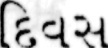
દિવસ
